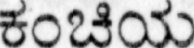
ಕಂಚಿಯ
